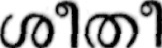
ശീതീ
